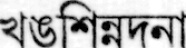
খঙশিন্নদনা
